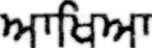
ਆਖਿਆ
